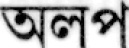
অলপ
